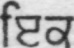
ਇਕ
